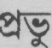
প্ৰভু
